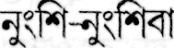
নুংশি-নুংশিবা
